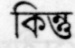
কিন্তু
